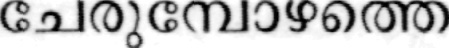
ചേരുമ്പോഴത്തെ
